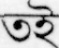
তই
